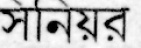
সিনিয়র
